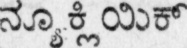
ನ್ಯೂಕ್ಲಿಯಿಕ್
